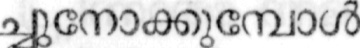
ച്ചുനോക്കുമ്പോള്‍
